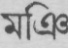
মঞি
